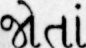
જોતાં
